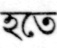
হতে
